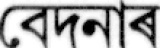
বেদনাৰ
